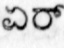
ಏರ್
